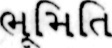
ભૂમિતિ
